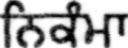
ਨਿਕੰਮਾ
